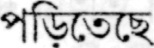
পড়িতেছে
